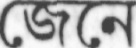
জেনে
